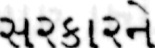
સરકારને
